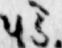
પડે.
